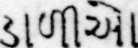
ડાળીઓ
